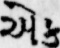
એક
